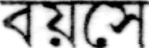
বয়সে
